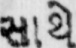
સાથે
